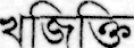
খজিক্তি
